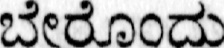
ಬೇರೊಂದು
